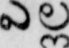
ಎಲ್ಲ
